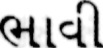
ભાવી
